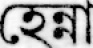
হেন্না
